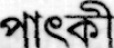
পাৎকী
